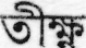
তীক্ষ্ণ
